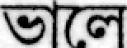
ভালে
